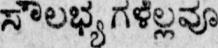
ಸೌಲಭ್ಯಗಳೆಲ್ಲವೂ
